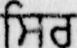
ਸਿਰ
